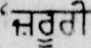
'ਜ਼ਰੂਰੀ
